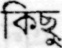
কিছু
